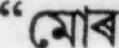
"মোৰ
